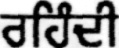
ਰਹਿੰਦੀ
